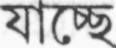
যাচ্ছে
